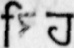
ਇਹ
